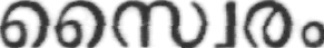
സ്വൈരം
